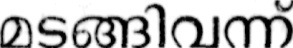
മടങ്ങിവന്ന്
